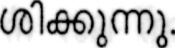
ശിക്കുന്നു.
